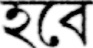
হবে
